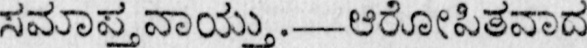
ಸಮಾಪ್ತವಾಯ್ತು.-ಆರೋಪಿತವಾದ
